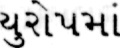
યુરોપમાં
